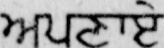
ਅਪਣਾਏ
